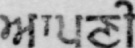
ਆਪਣੀ
